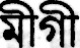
মীগী
